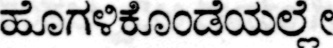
ಹೊಗಳಿಕೊಂಡೆಯಲ್ಲೇ
